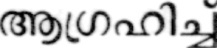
ആഗ്രഹിച്ച്
